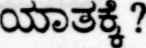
ಯಾತಕ್ಕೆ?
